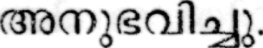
അനുഭവിച്ചു.
